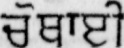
ਚੋਥਾਈ
